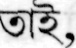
তাই,
